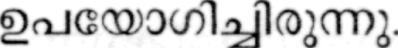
ഉപയോഗിച്ചിരുന്നു.
